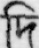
দি
